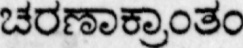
ಚರಣಾಕ್ರಾಂತಂ
